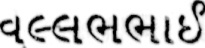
વલ્લભભાઈ
